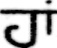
ਹਾਂ
